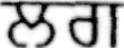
ਲਗ
